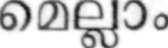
മെല്ലാം
